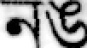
নঙ
